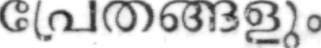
പ്രേതങ്ങളും
